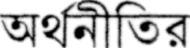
অর্থনীতির
